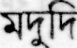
মদুদি
